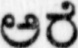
ಅರೆ
